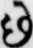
છે
